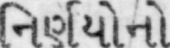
નિર્ણયોનો
